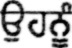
ਉਹਨੂੰ
